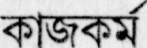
কাজকর্ম
